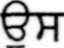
ਉਸ
